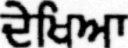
ਦੇਖਿਆ
